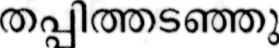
തപ്പിത്തടഞ്ഞു
